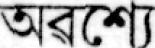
অৱশ্যে
